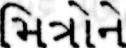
મિત્રોને
